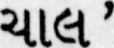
ચાલ'
